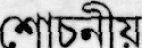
শোচনীয়
